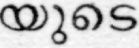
യുടെ
